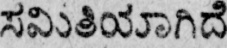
ಸಮಿತಿಯಾಗಿದೆ
